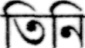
তিনি
